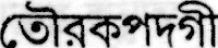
তৌরকপদগী
